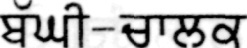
ਬੱਘੀ-ਚਾਲਕ
